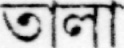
তালা
